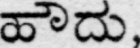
ಹೌದು,
